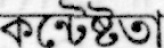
কন্টষ্টতা
